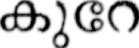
കുറേ
